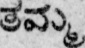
ತಮ್ಮ
